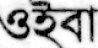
ওইবা
